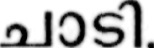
ചാടി.
